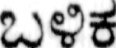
ಬಳಿಕ
